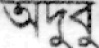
অদুবু
